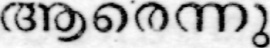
ആരെന്നു
